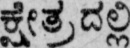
ಕ್ಷೇತ್ರದಲ್ಲಿ
